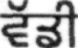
ਵੱਡੀ
